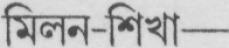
মিলন-শিখা-
